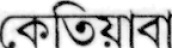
কেতিয়াবা
